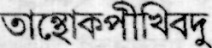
তান্থোকপীখিবদু
